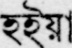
হইয়া
